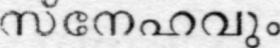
സ്നേഹവും
